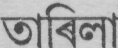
তাৰিলা
